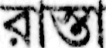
রাস্তা
